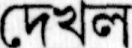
দেখল
